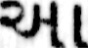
આ
